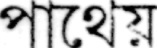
পাথেয়
